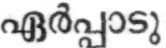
ഏര്‍പ്പാടു
